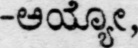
-ಅಯ್ಯೋ,
